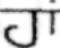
ਹਾਂ
